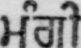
ਮੰਗੀ
